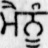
ਮੈਨੂੰ
